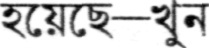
হয়েছে–খুন
